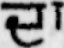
ਦਾ
